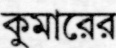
কুমারের
